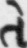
તે
